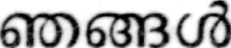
ഞങ്ങള്‍
